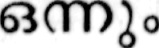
ഒന്നും
